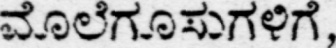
ಮೊಲೆಗೂಸುಗಳಿಗೆ,
